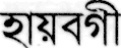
হায়বগী
